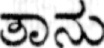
ತಾನು
